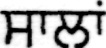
ਸਾਲਾਂ
